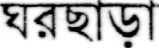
ঘরছাড়া
